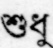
শুধু
